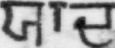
ਯਾਦ
